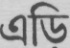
এড়ি
